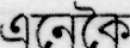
এনেকৈ
